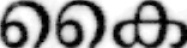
കൈ
